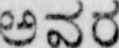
ಅವರ
